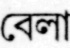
বেলা
